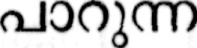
പാറുന്ന
